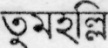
তুমহল্লি
